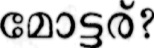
മോട്ടര്?
